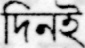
দিনই
